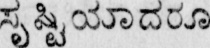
ಸೃಷ್ಟಿಯಾದರೂ
